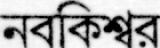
নবকিশ্বর
